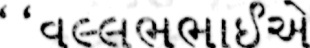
"વલ્લભભાઈએ
